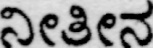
ನೀತೀನ
